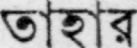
তাহার
